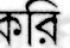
করি
